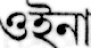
ওইনা
